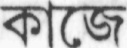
কাজে
